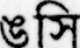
ঙসি
